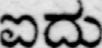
ಐದು
